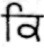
ਕਿ
